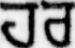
ਹਰ
